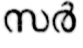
സര്‍
